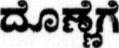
ದೊಣ್ಣೆಗೆ
